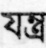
যন্ত্র
